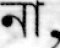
না,
